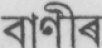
বাণীৰ
